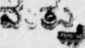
ಮತ್ತು
